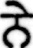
ਨੇ
